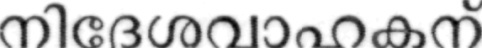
നിദേശവാഹകന്
